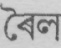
ৰৈল
